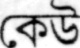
কেউ
